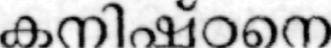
കനിഷ്ഠനെ
